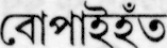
বোপাইহঁত
